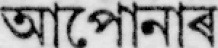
আপোনাৰ
